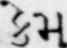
કેમ
